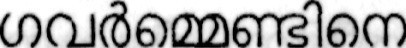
ഗവര്‍മ്മെണ്ടിനെ
